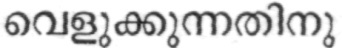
വെളുക്കുന്നതിനു
